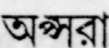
অপ্সরা
